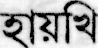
হায়খি
